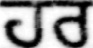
ਹਰ
